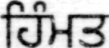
ਹਿੰਮਤ
